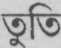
তুতি
